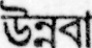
উন্নবা
